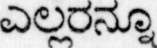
ಎಲ್ಲರನ್ನೂ
